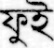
ফুই
